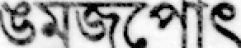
ঙমজপোৎ
